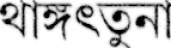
থাঙ্গৎতুনা
